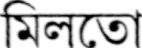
মিলতো
